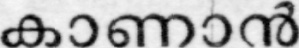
കാണാന്‍
